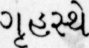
ગૃહસ્થે
